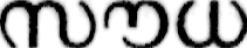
സൌധ
